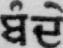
ਬੰਦੇ
